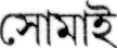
সোমাই
